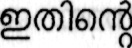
ഇതിന്റെ
